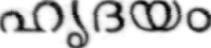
ഹൃദയം
